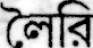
লৈরি
